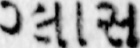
ગ્લાસ
